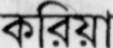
করিয়া
